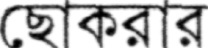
ছোকরার
